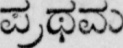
ಪ್ರಥಮ
